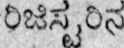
ರಿಜಿಸ್ಟರಿನ
